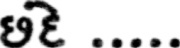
છંદે..........
